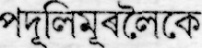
পদূলিমূৰলৈকে
